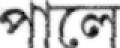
পালে
